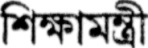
শিক্ষামন্ত্রী
